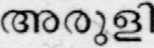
അരുളി
